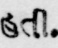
હતી.
